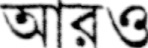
আরও
